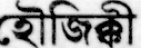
হৌজিক্কী
